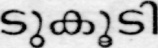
ടുകൂടി
